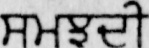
ਸਮਝਦੀ
